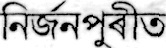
নির্জনপুৰীত
